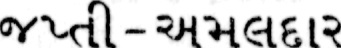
જપ્તી-અમલદાર
